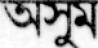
অসুম
